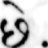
છે.
